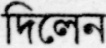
দিলেন
